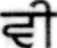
ਵੀ
